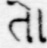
તો
